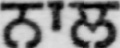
ਨਾਲ
